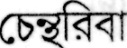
চেন্থরিবা
